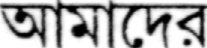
আমাদের
